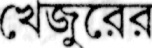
খেজুরের
